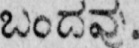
ಬಂದವು.
